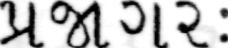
પ્રજાગરઃ
